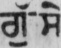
ਗੁੱਸੇ
